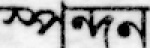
স্পন্দন
